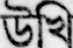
উখি
